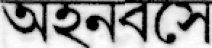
অহনবসে
